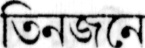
তিনজনে
